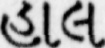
હાલ
